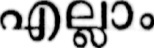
എല്ലാം
